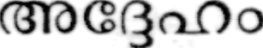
അദ്ദേഹം
